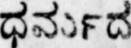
ಧರ್ಮದ
